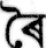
ৰৈ
